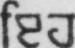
ਇਹ
